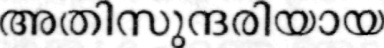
അതിസുന്ദരിയായ
